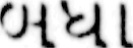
બધા
